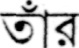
তাঁর
